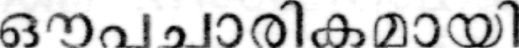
ഔപചാരികമായി
